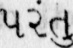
પરંતુ
